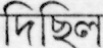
দিছিল
